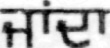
ਜਾਂਦਾ
